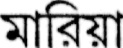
মারিয়া
